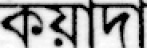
কয়াদা
